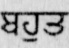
ਬਹੁਤ
